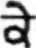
ਕੇ
